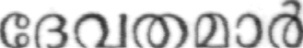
ദേവതമാര്‍
